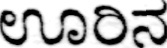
ಊರಿನ
